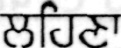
ਲਹਿਣਾ
